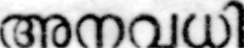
അനവധി
